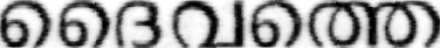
ദൈവത്തെ
